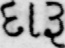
દારૂ
